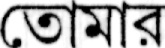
তোমার
